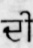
ਦੀ
